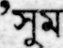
’সুম
